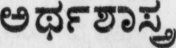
ಅರ್ಥಶಾಸ್ತ್ರ
